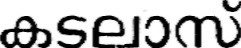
കടലാസ്
